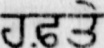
ਹਫ਼ਤੇ
